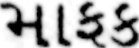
માફક
